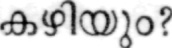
കഴിയും?
